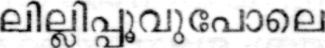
ലില്ലിപ്പൂവുപോലെ
